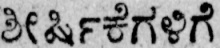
ಶೀರ್ಷಿಕೆಗಳಿಗೆ
